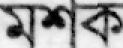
মশক
